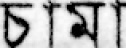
চামা
